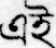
এই
